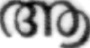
ആ
